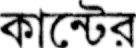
কান্টের
